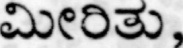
ಮೀರಿತು,
